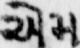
એમ
